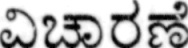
ವಿಚಾರಣೆ
